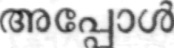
അപ്പോള്‍
